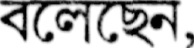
বলেছেন,
